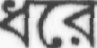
ধরে
